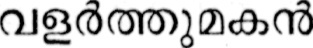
വളര്‍ത്തുമകന്‍
